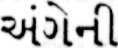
અંગેની
